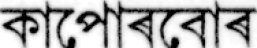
কাপোৰবোৰ
